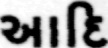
આદિ
